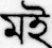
মই
